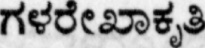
ಗಳರೇಖಾಕೃತಿ
